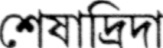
শেষাদ্রিদা
